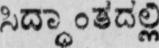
ಸಿದ್ದಾಂತದಲ್ಲಿ
